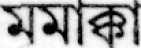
মমাক্কা
